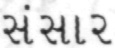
સંસાર
